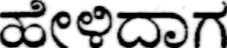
ಹೇಳಿದಾಗ
